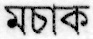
মচাক
